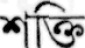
শক্তি
